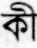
কী
